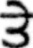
ਤੇ
